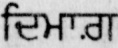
ਦਿਮਾਗ਼
